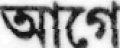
আগে
